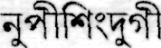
নুপীশিংদুগী
